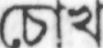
চোখ
